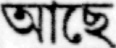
আছে
